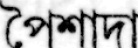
পৈশাদা
